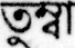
তুম্বা
